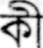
কী
